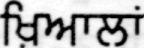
ਖ਼ਿਆਲਾਂ
